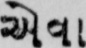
એવા
